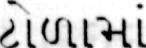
ટોળામાં
